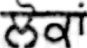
ਲੋਕਾਂ
